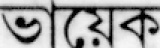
ভায়েক
